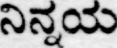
ನಿನ್ನಯ
